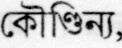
কৌণ্ডিন্য,
